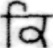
ਕਿ
